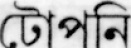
টোপনি
